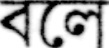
বলে
